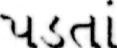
પડતાં
